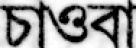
চাওবা
